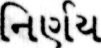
નિર્ણય
